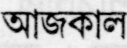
আজকাল
